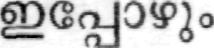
ഇപ്പോഴും
